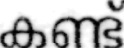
കണ്ട്
